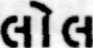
લોલ
